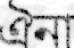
ঐনা
